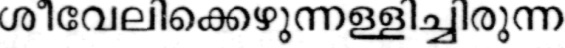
ശീവേലിക്കെഴുന്നള്ളിച്ചിരുന്ന
